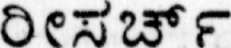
ರೀಸರ್ಚ್
